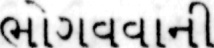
ભોગવવાની
